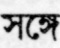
সঙ্গে
